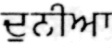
ਦੁਨੀਆ
